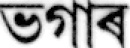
ভগাৰ
